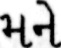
મને
